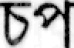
চপ
